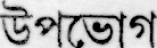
উপভোগ
